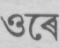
ওৰে
